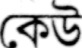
কেউ
